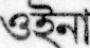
ওইনা
